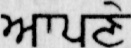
ਆਪਣੇ
